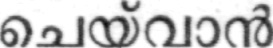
ചെയ്വാന്‍
